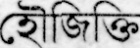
হৌজিক্তি
